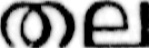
തല
